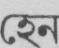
হেন
